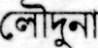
লৌদুনা
